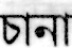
চানা
